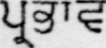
ਪ੍ਰਭਾਵ
